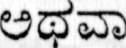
ಅಥವಾ
